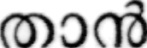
താന്‍
